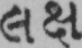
લક્ષ
